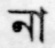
না
